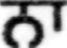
ਨਾ
